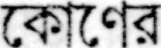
কোণের
